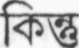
কিন্তু
